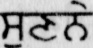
ਸੁਣਨੇ
